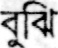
বুঝি
